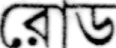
রোড
